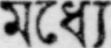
মধ্যে
